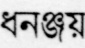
ধনঞ্জয়
